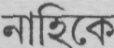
নাহিকে
